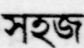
সহজ
